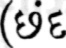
(છંદ
